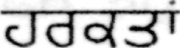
ਹਰਕਤਾਂ
